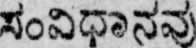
ಸಂವಿಧಾನವು
